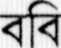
ববি
